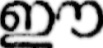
ഈ
